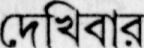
দেখিবার
